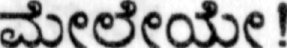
ಮೇಲೇಯೇ!
